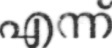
എന്ന്
